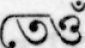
তেওঁ
